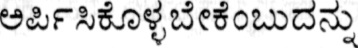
ಅರ್ಪಿಸಿಕೊಳ್ಳಬೇಕೆಂಬುದನ್ನು
